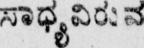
ಸಾಧ್ಯವಿರುವ
